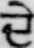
ਦੇ
